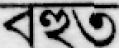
বহুত
